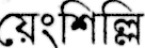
য়েংশিল্লি
